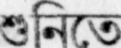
শুনিতে
